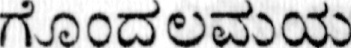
ಗೊಂದಲಮಯ
